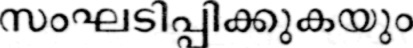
സംഘടിപ്പിക്കുകയും
